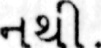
નથી.
